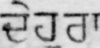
ਦੇਹੁਰਾ
